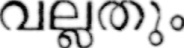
വല്ലതും
